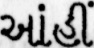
આંહીં
